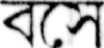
বসে
